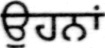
ਉਹਨਾਂ
